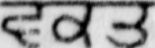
ਵਕਤ
